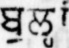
ਬੁਲ੍ਹਾਂ
